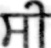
ਸੀ
